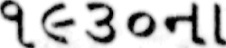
૧૯૩૦ના
